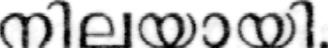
നിലയായി.
